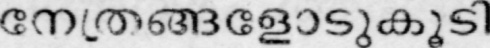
നേത്രങ്ങളോടുകൂടി
